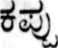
ಕಪ್ಪು
